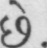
છે.
